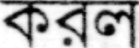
করল
